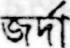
জর্দা
